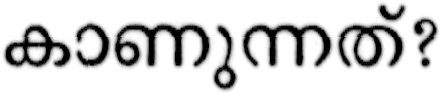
കാണുന്നത്?
